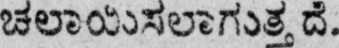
ಚಲಾಯಿಸಲಾಗುತ್ತದೆ.
